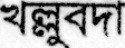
খল্লুবদা
